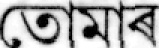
তোমাৰ
